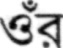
ওঁর
